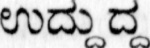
ಉದ್ದುದ್ದ
